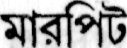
মারপিট
